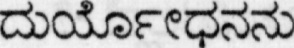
ದುರ್ಯೋಧನನು
